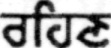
ਰਹਿਣ
